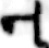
ન
